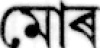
মোৰ
